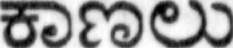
ಕಾಣಲು
